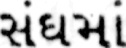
સંઘમાં
